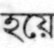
হয়ে
